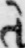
તે
